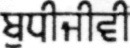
ਬੁਧੀਜੀਵੀ
